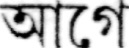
আগে
